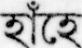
হাঁহে
